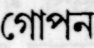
গোপন
